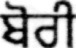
ਬੋਰੀ
